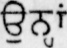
ਉਨ੍ਹਾਂ
